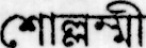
শোল্লম্মী
